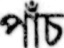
পাঁচ
